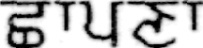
ਛਾਪਣਾ
